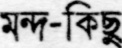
মন্দ-কিছু
